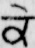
ਕੇ
